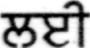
ਲਈ
